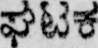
ಘಟಕ
